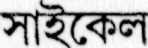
সাইকেল
